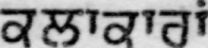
ਕਲਾਕਾਰਾਂ
